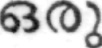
ഒരു
